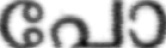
പോ
